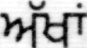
ਅੱਖਾਂ
